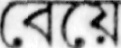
বেয়ে
